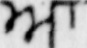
ਆ
